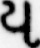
ય
